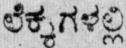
ಲೆಕ್ಕಗಳಲ್ಲಿ
